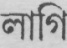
লাগি
